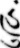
હું
